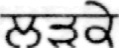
ਲੜਕੇ
